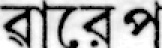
ৱারেপ
